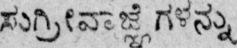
ಸುಗ್ರೀವಾಜ್ಞೆಗಳನ್ನು
